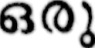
ഒരു
